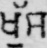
ਖੁੱਸ
